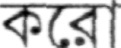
করো
